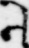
ને
